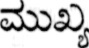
ಮುಖ್ಯ
